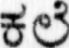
ಕಲೆ
